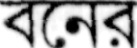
বনের
